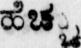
ಹೆಚ್ಚು
